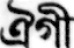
ঐগী
